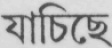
যাচিছে
